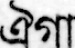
ঐগা
